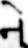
ને
